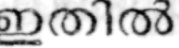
ഇതില്‍
